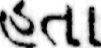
હતા
